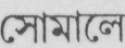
সোমালে
